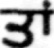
ਤਾਂ
